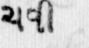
સાચવી
